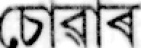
চোৱাৰ
